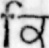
ਕਿ
